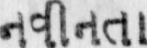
નવીનતા
